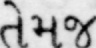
તેમજ
